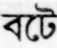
বটে
